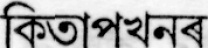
কিতাপখনৰ
